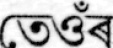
তেওঁৰ
